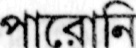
পারোনি
